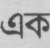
এক
